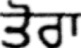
ਤੋਰਾ
